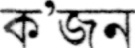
ক’জন
